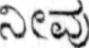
ನೀವು
